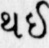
થઈ
